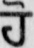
ਹੋ
